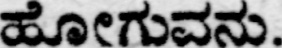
ಹೋಗುವನು.
